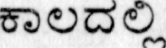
ಕಾಲದಲ್ಲಿ
